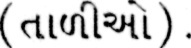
(તાળીઓ).
